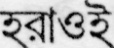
হরাওই
